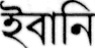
ইবানি
